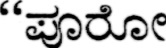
"ಪೂರೋ
